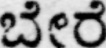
ಬೇರೆ
